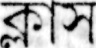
ক্লাস
